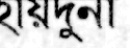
হায়দুনা
